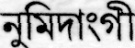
নুমিদাংগী
